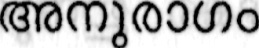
അനുരാഗം
